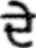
ਦੇ
